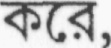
করে,
